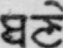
ਬਣੇ
